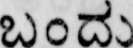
ಬಂದು
